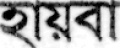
হায়বা
